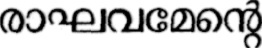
രാഘവമേന്റെ
